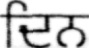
ਦਿਨ
